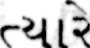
ત્યારે
